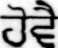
ਹੋਵੈ
